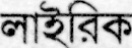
লাইরিক
